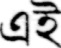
এই
